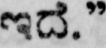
ಇದೆ.”
